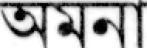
অমনা
